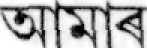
আমাৰ
